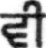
ਵੀ
